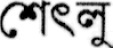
শেৎলু
